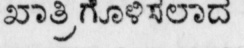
ಖಾತ್ರಿಗೊಳಿಸಲಾದ
